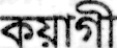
কয়াগী
